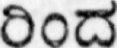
ರಿಂದ
